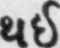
થઈ
